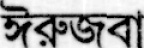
ঈরুজবা
